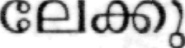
ലേക്കു
